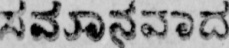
ಸಮಾನವಾದ
